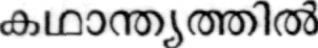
കഥാന്ത്യത്തില്‍
